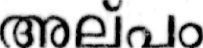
അല്പം
